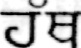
ਹੱਥ
